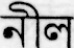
নীল
